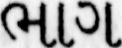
ભાગ
